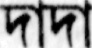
দাদা
